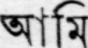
আমি
